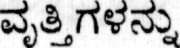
ವೃತ್ತಿಗಳನ್ನು
